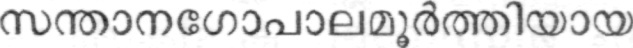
സന്താനഗോപാലമൂര്‍ത്തിയായ
